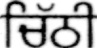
ਚਿੱਠੀ
